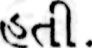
હતી.
